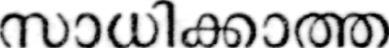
സാധിക്കാത്ത
